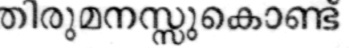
തിരുമനസ്സുകൊണ്ട്
